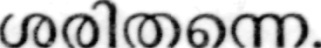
ശരിതന്നെ.
